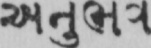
અનુભવ
